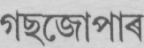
গছজোপাৰ
